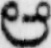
ಆ
